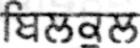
ਬਿਲਕੁਲ
